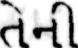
તેની
